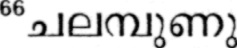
66ചലമ്പുണു
